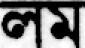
লম
